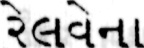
રેલવેના
